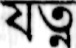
যত্ন
